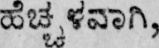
ಹೆಚ್ಚಳವಾಗಿ,
